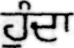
ਹੁੰਦਾ
